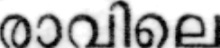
രാവിലെ
